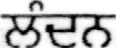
ਲੰਦਨ
